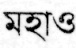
মহাও
